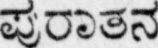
ಪುರಾತನ
